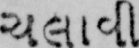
ચલાવી
